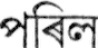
পৰিল
